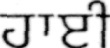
ਹਾਈ
